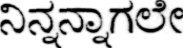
ನಿನ್ನನ್ನಾಗಲೇ
